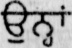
ਉਨ੍ਹਾਂ
